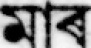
মাৰ
